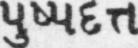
પુષ્પદત્ત
